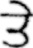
ਤੇ
